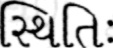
સ્થિતિઃ
